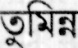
তুমিন্ন
